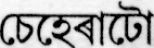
চেহেৰাটো
